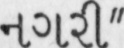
નગરી"
